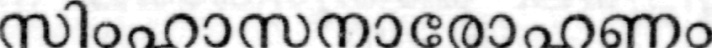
സിംഹാസനാരോഹണം
